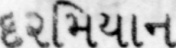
દરમિયાન
